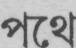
পথে
